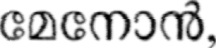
മേനോന്‍,
